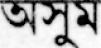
অসুম
